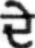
ਦੇ
